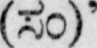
(ಸಂ)’
